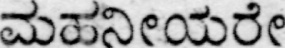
ಮಹನೀಯರೇ
